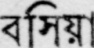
বসিয়া
